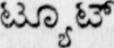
ಟ್ಯೂಟ್
